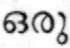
ഒരു
